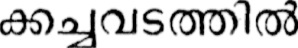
ക്കച്ചവടത്തില്‍
